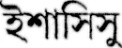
ইশাসিসু
